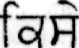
ਕਿਸੇ
